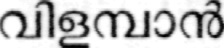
വിളമ്പാന്‍
